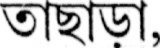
তাছাড়া,
